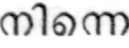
നിന്നെ
